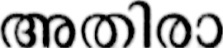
അതിരാ
